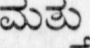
ಮತ್ತು
